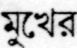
মুখের
